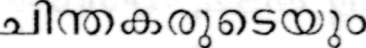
ചിന്തകരുടെയും
